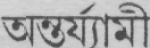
অন্তৰ্য্যামী
